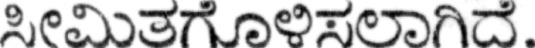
ಸೀಮಿತಗೊಳಿಸಲಾಗಿದೆ.
